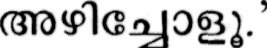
അഴിച്ചോളൂ.’
